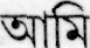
আমি
